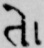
તો
